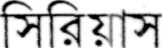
সিরিয়াস
